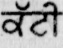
ਕੱਟੀ
